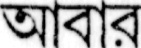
আবার
